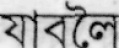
যাবলৈ
